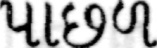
પાછળ
